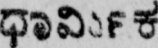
ಧಾರ್ಮಿಕ
